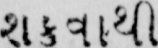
શકવાથી
